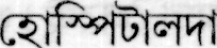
হোস্পিটালদা
